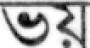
ভয়
